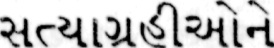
સત્યાગ્રહીઓને
